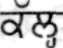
ਕੱਲ੍ਹ
